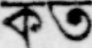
কত
